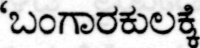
‘ಬಂಗಾರಕುಲಕ್ಕೆ
